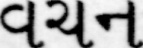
વચન
